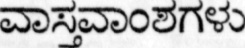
ವಾಸ್ತವಾಂಶಗಳು
